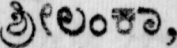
ಶ್ರೀಲಂಕಾ,
